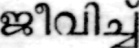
ജീവിച്ച്
